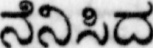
ನೆನಿಸಿದ
